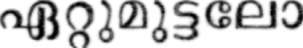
ഏറ്റുമുട്ടലോ
